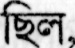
ছিল,
